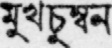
মুখচুম্বন
